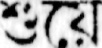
শুয়ে
